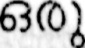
ഒരു
